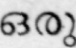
ഒരു
